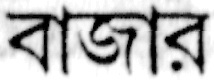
বাজার
